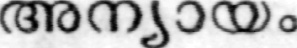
അന്യായം
